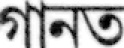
গানত
